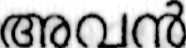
അവന്‍
